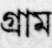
গ্রাম
